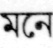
মনে
